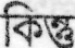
কিন্তু
